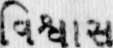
વિશ્વાસ
